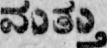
ಮತ್ತು
